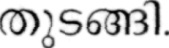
തുടങ്ങി.
